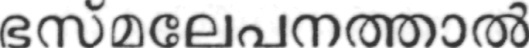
ഭസ്മലേപനത്താല്‍
